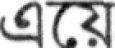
এয়ে
